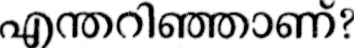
എന്തറിഞ്ഞാണ്?
